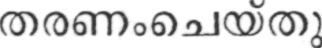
തരണംചെയ്തു
